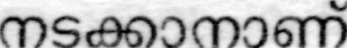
നടക്കാനാണ്
